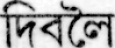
দিবলৈ
